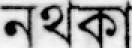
নথকা
